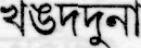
খঙদদুনা
